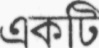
একটি
